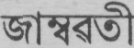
জাম্বৱতী
